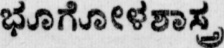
ಭೂಗೋಳಶಾಸ್ತ್ರ
